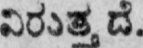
ವಿರುತ್ತದೆ.
